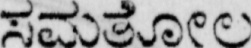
ಸಮತೋಲ
